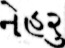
નેહરુ
